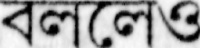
বললেও
